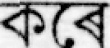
কৰে
